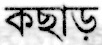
কছাড়
